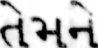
તેમને
